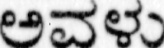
ಅವಳು
